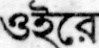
ওইরে
